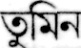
তুমিন
